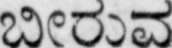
ಬೀರುವ
